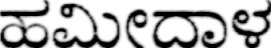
ಹಮೀದಾಳ
